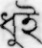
ধুই
